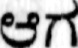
ಆಗ
